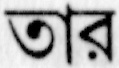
তার
